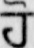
ਹੋ
